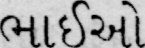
ભાઈઓ
